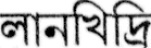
লানখিদ্রি
